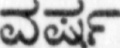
ವರ್ಷ
